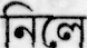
নিলে
